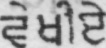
ਵੇਖੀਏ
